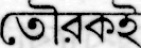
তৌরকই
